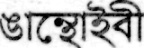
ঙান্থোইবী
